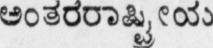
ಅಂತರರಾಷ್ಟ್ರೀಯ
